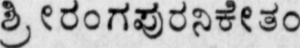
ಶ್ರೀರಂಗಪುರನಿಕೇತಂ
